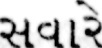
સવારે
